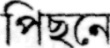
পিছনে
